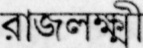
রাজলক্ষ্মী
